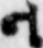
ન
